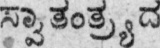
ಸ್ವಾತಂತ್ರ್ಯದ
